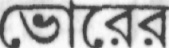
ভোরের
